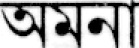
অমনা
